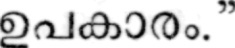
ഉപകാരം."
